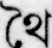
থৈ
